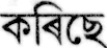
কৰিছে
